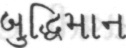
બુદ્ધિમાન
